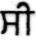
ਸੀ
